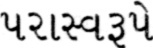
પરાસ્વરૂપે
